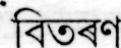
বিতৰণ
